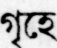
গৃহে
